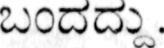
ಬಂದದ್ದು.
